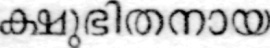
ക്ഷുഭിതനായ
